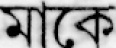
মাকে
